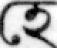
হে
